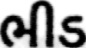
ભીડ
